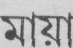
মায়া
